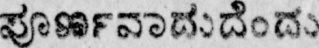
ಪೂರ್ಣವಾದುದೆಂದು
